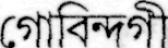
গোবিন্দগী
